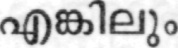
എങ്കിലും
